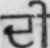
ਦੀ
